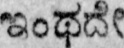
ಇಂಥದೇ
